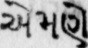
એમણે
